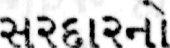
સરદારનો
